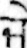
ਜੇ
